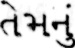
તેમનું
